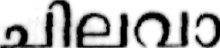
ചിലവാ
